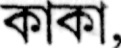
কাকা,
